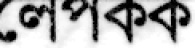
লেপকক
